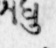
બધું
